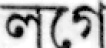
লগে
